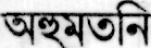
অহুমতনি
